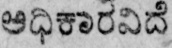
ಅಧಿಕಾರವಿದೆ
